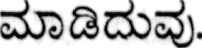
ಮಾಡಿದುವು.
